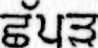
ਛੱਪੜ
